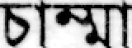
চাম্মা
